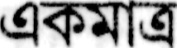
একমাত্র
